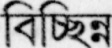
বিচ্ছিন্ন
